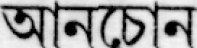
আনচোন
